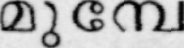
മുമ്പേ
